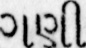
ગણી
